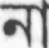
না
